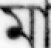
মা
